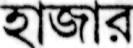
হাজার
